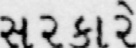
સરકારે
